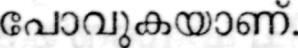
പോവുകയാണ്.
